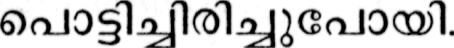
പൊട്ടിച്ചിരിച്ചുപോയി.
